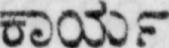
ಕಾರ್ಯ
